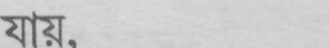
যায়,
